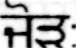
ਜੋੜ:
